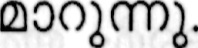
മാറുന്നു.
